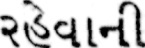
રહેવાની
